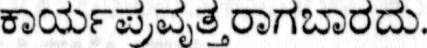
ಕಾರ್ಯಪ್ರವೃತ್ತರಾಗಬಾರದು.
